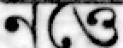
নত্তে
